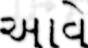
આવે
